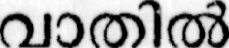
വാതില്‍
